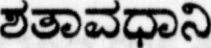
ಶತಾವಧಾನಿ
